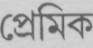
প্ৰেমিক
